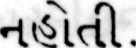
નહોતી.
